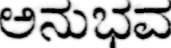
ಅನುಭವ
